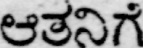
ಆತನಿಗೆ
